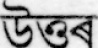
উত্তৰ
